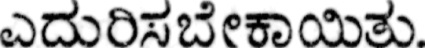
ಎದುರಿಸಬೇಕಾಯಿತು.
